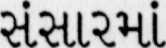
સંસારમાં
